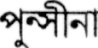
পুন্সীনা
